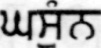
ਘਸੁੰਨ
